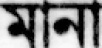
মানা
